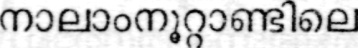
നാലാംനൂറ്റാണ്ടിലെ
